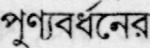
পুণ্যবর্ধনের
